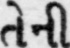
તેની
